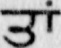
ਤਾਂ
